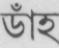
ডাঁহ
